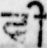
ਵੀ
